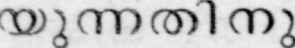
യുന്നതിനു
